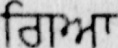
ਗਿਆ
